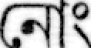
নোং
